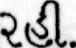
રહી.
